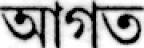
আগত
